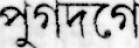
পুগদগে
